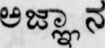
ಅಜ್ಞಾನ
